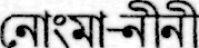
নোংমা-নীনী
